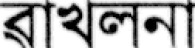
ৱাখলনা
